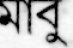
মাবু
